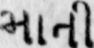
માની
